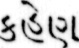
કહેણ
